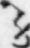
કે
